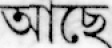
আছে
